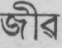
জীৱ
